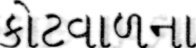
કોટવાળના
